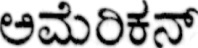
ಅಮೆರಿಕನ್
